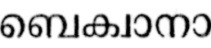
ബെക്വാനാ
